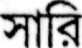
সারি
